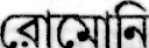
রোমোনি
